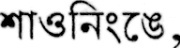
শাওনিংঙে,
